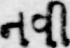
નવી
